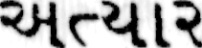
અત્યાર
